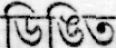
ডিঙিত
